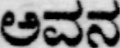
ಅವನ
